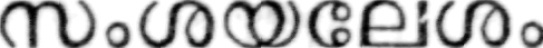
സംശയലേശം
